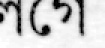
লগে
